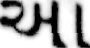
આ
